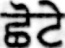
ਛੋਟੇ
